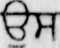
ਉਸ
